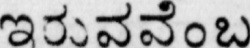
ಇರುವವೆಂಬ
